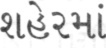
શહેરમાં
